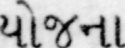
યોજના
